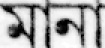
মানা
